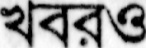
খবরও
